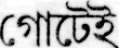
গোটেই
